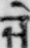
ਜੇ
